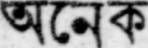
অনেক
